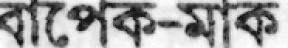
বাপেক-মাক
